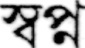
স্বপ্ন
